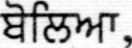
ਬੋਲਿਆ,
